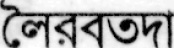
লৈরবতদা
